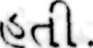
હતી.
